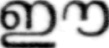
ഈ
